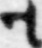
ન
